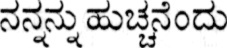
ನನ್ನನ್ನುಹುಚ್ಚನೆಂದು
